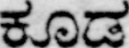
ಕೂಡ
